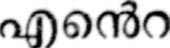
എന്റെ
